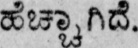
ಹೆಚ್ಚಾಗಿದೆ.
